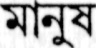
মানুষ
